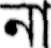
না
